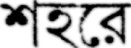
শহরে
